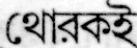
থোরকই
